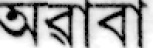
অৱাবা
